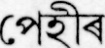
পেহীৰ
